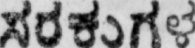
ಸರಕುಗಳ
